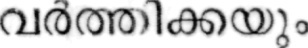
വര്‍ത്തിക്കയും
